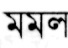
মমল
